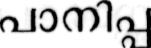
പാനിപ്പ
